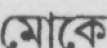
মোকে
